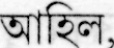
আহিল,
